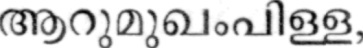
ആറുമുഖംപിള്ള,
